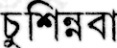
চুশিন্নবা
